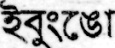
ইবুংঙো
